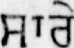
ਸਾਰੇ
